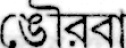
ঙৌরবা
